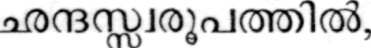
ഛന്ദസ്സ്വരൂപത്തില്‍,
